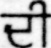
ਦੀ
